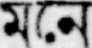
মনে
